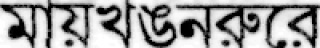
মায়খঙনরুরে
